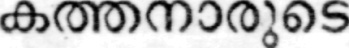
കത്തനാരുടെ
